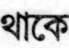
থাকে
